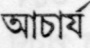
আচার্য
